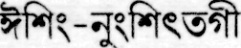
ঈশিং-নুংশিৎতগী
